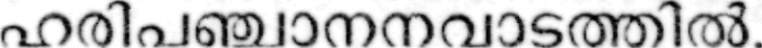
ഹരിപഞ്ചാനനവാടത്തില്‍.
